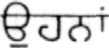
ਉਹਨਾਂ
